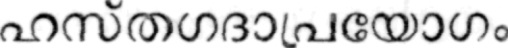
ഹസ്തഗദാപ്രയോഗം
